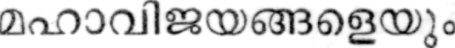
മഹാവിജയങ്ങളെയും
